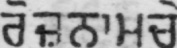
ਰੋਜ਼ਨਾਮਚੇ
